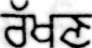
ਰੱਖਣ
